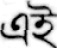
এই
